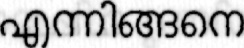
എന്നിങ്ങനെ
